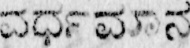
ವರ್ಧಮಾನ
